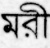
মরী
